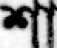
শা
